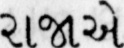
રાજાએ
